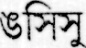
ঙসিসু
